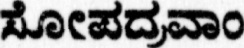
ಸೋಪದ್ರವಾ೦
